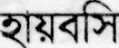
হায়বসি
